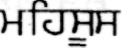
ਮਹਿਸੂਸ
